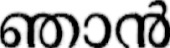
ഞാന്‍
